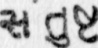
સંતુષ્ટ
